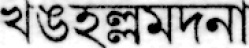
খঙহল্লমদনা
